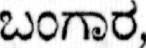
ಬಂಗಾರ,
